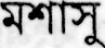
মশাসু
